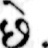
છે.
